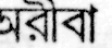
অরীবা
